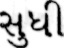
સુધી
